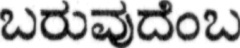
ಬರುವುದೆಂಬ
